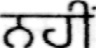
ਨਹੀਂ
